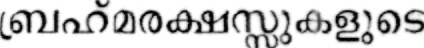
ബ്രഹ്മരക്ഷസ്സുകളുടെ
